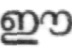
ഈ
